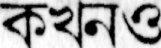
কখনও
